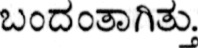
ಬಂದಂತಾಗಿತ್ತು.
